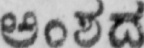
ಅಂಶದ
